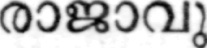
രാജാവു
